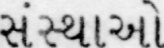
સંસ્થાઓ
